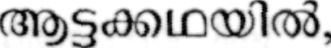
ആട്ടക്കഥയില്‍,
